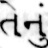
તેનું
